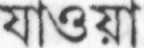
যাওয়া
